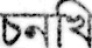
চনখি
